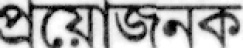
প্রয়োজনক
